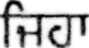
ਜਿਹਾ
